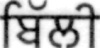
ਬਿੱਲੀ
